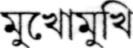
মুখোমুখি
